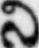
ನಿ
